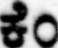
ಕೆಂ
